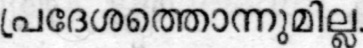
പ്രദേശത്തൊന്നുമില്ല.
